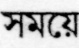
সময়ে
